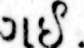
ગઈ.
